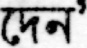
দেন’
